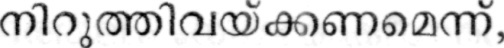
നിറുത്തിവയ്ക്കണമെന്ന്,
